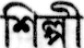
শিল্পী
